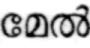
മേല്‍
